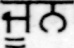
ਜੂਨ
